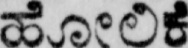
ಹೋಲಿಕೆ
